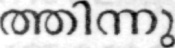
ത്തിന്നു
